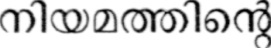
നിയമത്തിന്റെ
